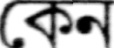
কেন
